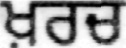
ਖ਼ਰਚ
